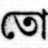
তো
